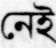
নেই
